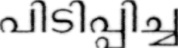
പിടിപ്പിച്ച
